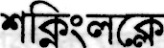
শক্নিংলক্লে
